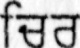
ਚਿਰ
